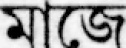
মাজে
